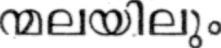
ന്മലയിലും
